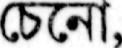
চেনো,
